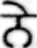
ਨੇ
